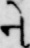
ને
